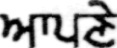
ਆਪਣੇ
